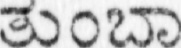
ತುಂಬಾ
